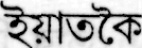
ইয়াতকৈ
